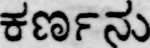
ಕರ್ಣನು
